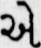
એ
